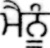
ਮੈਨੂੰ
